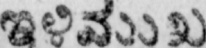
ಇಳಿಮುಖ
